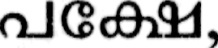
പക്ഷേ,
